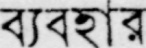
ব্যবহার
